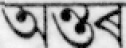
অন্তৰ
